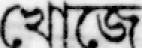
খোজে
